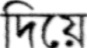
দিয়ে
